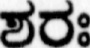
ಶರಃ
